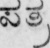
ಪತ್ರ
